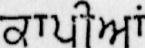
ਕਾਪੀਆਂ
